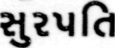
સુરપતિ
